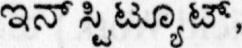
ಇನ್‌ಸ್ಟಿಟ್ಯೂಟ್,
